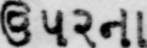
ઉપરના
